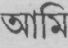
আমি
